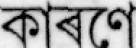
কাৰণে
